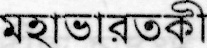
মহাভারতকী
